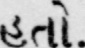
હતો.
